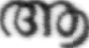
ആ
